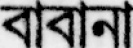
বাবানা
